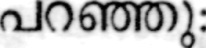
പറഞ്ഞു:
